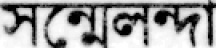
সম্মেলন্দা
